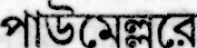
পাউমেল্লরে
